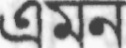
এমন
